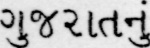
ગુજરાતનું
